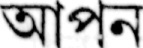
আপন
